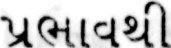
પ્રભાવથી
